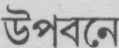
উপবনে
